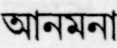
আনমনা
